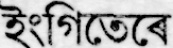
ইংগিতেৰে
